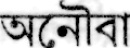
অনৌবা
